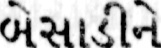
બેસાડીને
